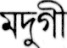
মদুগী
